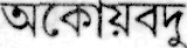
অকোয়বদু
